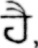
ਹੈ,
